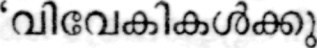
‘വിവേകികള്‍ക്കു
